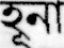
হূনা
